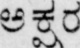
ಅಕ್ಷರ
